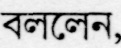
বললেন,
